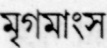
মৃগমাংস
